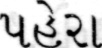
પહેરા
